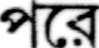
পরে
